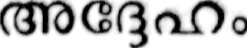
അദ്ദേഹം
